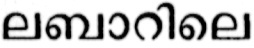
ലബാറിലെ
